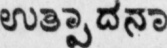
ಉತ್ಪಾದನಾ
